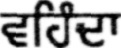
ਵਹਿੰਦਾ
